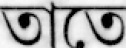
তাতে
